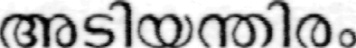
അടിയന്തിരം
